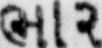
ભાર
